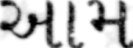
આમ
